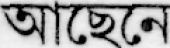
আছেনে
